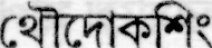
থৌদোকশিং
